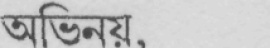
অভিনয়,
